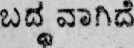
ಬದ್ಧವಾಗಿದೆ
